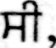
ਸੀ,
